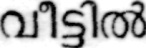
വീട്ടില്‍
